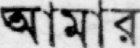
আমার
